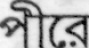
পীরে
